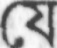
যে
